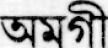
অমগী
